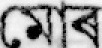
মোৰ
